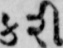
કરી
